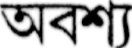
অবশ্য
